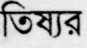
তিষ্যর
